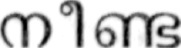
നീണ്ട
